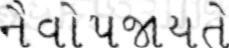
નૈવોપજાયતે
